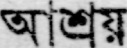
আশ্রয়
